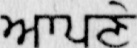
ਆਪਣੇ
